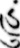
હું
